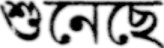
শুনেছে
